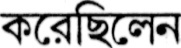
করেছিলেন
